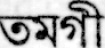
তমগী
